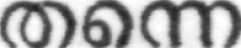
തന്നെ
